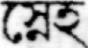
স্নেহ
